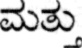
ಮತ್ತು
